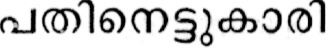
പതിനെട്ടുകാരി
